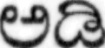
ಅಡಿ
